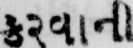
કરવાની
